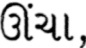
ઊંચા,
